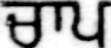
ਚਾਪ
